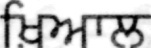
ਖ਼ਿਆਲ
